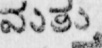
ಮತ್ತು
